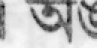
অঙ
